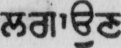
ਲਗਾਉਣ
